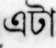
এটা
